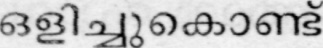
ഒളിച്ചുകൊണ്ട്
